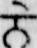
ਨੇ
